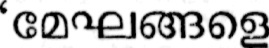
‘മേഘങ്ങളെ
